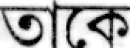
তাকে
